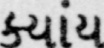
ક્યાંય
